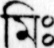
মিঃ
